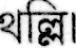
থল্লি।
